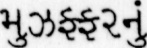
મુઝફ્ફરનું
